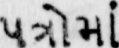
પત્રોમાં
